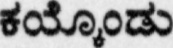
ಕಯ್ಕೊಂಡು
